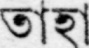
তাহা
